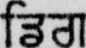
ਡਿਗ
